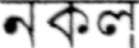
নকল
